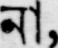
না,
